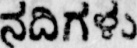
ನದಿಗಳು
